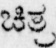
ಚಿತ್ರ
